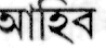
আহিব
